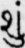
શું
